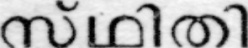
സ്ഥിതി
